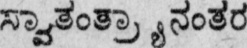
ಸ್ವಾತಂತ್ರ್ಯಾನಂತರ
